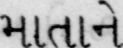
માતાને
